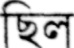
ছিল
